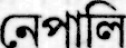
নেপালি
